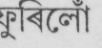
ফুৰিলোঁ
